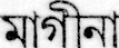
মাগীনা
